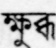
ক্ষুব্ধ
